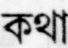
কথা
